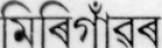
মিৰিগাঁৱৰ
